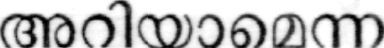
അറിയാമെന്ന
